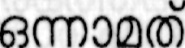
ഒന്നാമത്
